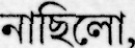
নাছিলো,
